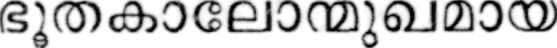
ഭൂതകാലോന്മുഖമായ
